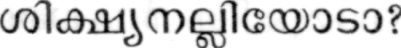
ശിക്ഷ്യനല്ലിയോടാ?
